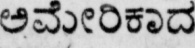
ಅಮೇರಿಕಾದ
